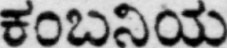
ಕಂಬನಿಯ
